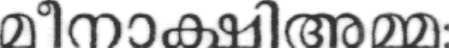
മീനാക്ഷിഅമ്മ:
